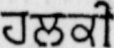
ਹਲਕੀ
